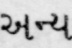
અન્ય
